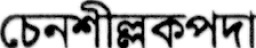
চেনশীল্লকপদা
